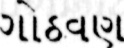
ગોઠવણ
